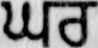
ਘਰ
